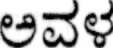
ಅವಳ
